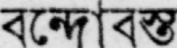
বন্দোবস্ত
